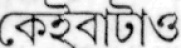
কেইবাটাও
